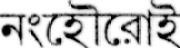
নংহৌরোই
